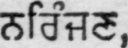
ਨਰਿੰਜਣ,
